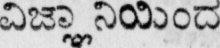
ವಿಜ್ಞಾನಿಯಿಂದ
